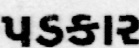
પડકાર
